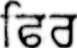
ਫਿਰ
